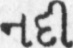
નદી
